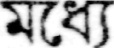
মধ্যে
